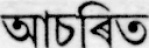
আচৰিত
